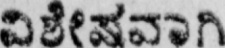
ವಿಶೇಷವಾಗಿ
